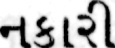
નકારી
